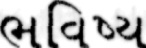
ભવિષ્ય
